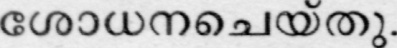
ശോധനചെയ്തു.
